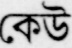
কেউ
